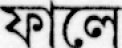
ফালে
